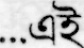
...এই
